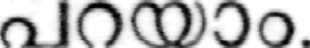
പറയാം.
